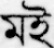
মই
